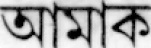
আমাক
